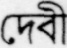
দেবী
